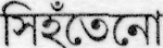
সিহঁতেনো
